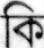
কি
